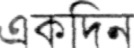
একদিন
